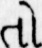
તો
